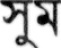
সুম
